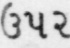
ઉપર
